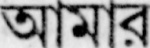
আমার
